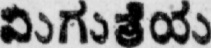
ಮಿಗುತೆಯ
